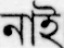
নাই
